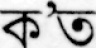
ক'ত
